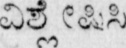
ವಿಶ್ಲೇಷಿಸಿ
